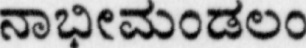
ನಾಭೀಮಂಡಲಂ
